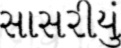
સાસરીયું
